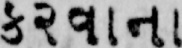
કરવાના
